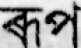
ৰূপ
